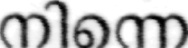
നിന്നെ
